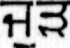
ਜੁੜ
